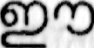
ഈ
